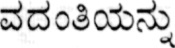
ವದಂತಿಯನ್ನು
